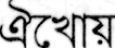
ঐখোয়
